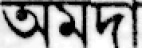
অমদা
